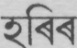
হৰিৰ
